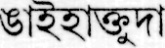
ঙাইহাক্তুদা
